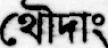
থৌদাং
